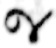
જ
